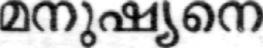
മനുഷ്യനെ
